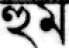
হুম
